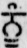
ਨੂੰ
